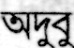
অদুবু
